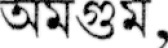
অমগুম,
